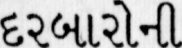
દરબારોની
